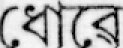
ধোৱে
